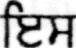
ਇਸ
